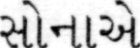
સોનાએ
